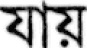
যায়
